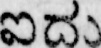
ಐದು
